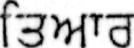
ਤਿਆਰ
